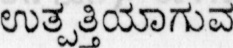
ಉತ್ಪತ್ತಿಯಾಗುವ
